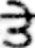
ਤੇ
